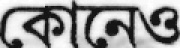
কোনেও
